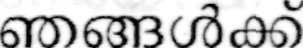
ഞങ്ങള്‍ക്ക്
